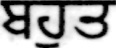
ਬਹੁਤ
